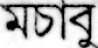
মচাবু
